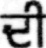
ਦੀ
